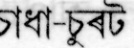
চাধা-চুৰট
